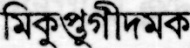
মিকুপ্তুগীদমক
